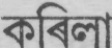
কৰিলা
